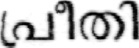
പ്രീതി
